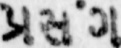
પ્રસંગ
